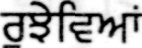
ਰੁਝੇਵਿਆਂ
